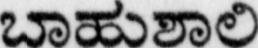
ಬಾಹುಶಾಲಿ
